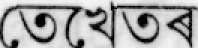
তেখেতৰ
